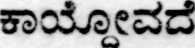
ಕಾಯ್ದೋವದೆ
